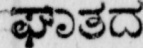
ಘಾತದ
